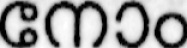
നോം
